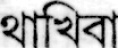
থাখিবা
